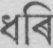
ধৰি
